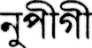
নুপীগী
